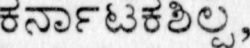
ಕರ್ನಾಟಕಶಿಲ್ಪ,
